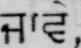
ਜਾਵੇ,
